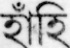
হাঁহি
